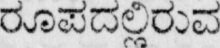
ರೂಪದಲ್ಲಿರುವ
